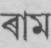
ৰাম
